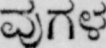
ವುಗಳ
